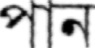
পান
